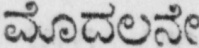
ಮೊದಲನೇ
